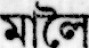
মালৈ
